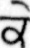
ਕੇ
